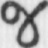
જ
